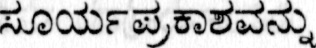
ಸೂರ್ಯಪ್ರಕಾಶವನ್ನು
